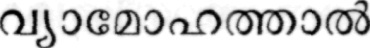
വ്യാമോഹത്താല്‍
